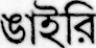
ঙাইরি
